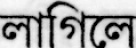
লাগিলে
